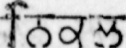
ਨਿਕਲ
